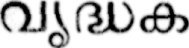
വൃദ്ധക
